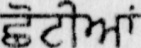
ਛੋਟੀਆਂ
